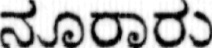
ನೂರಾರು
